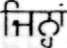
ਜਿਨ੍ਹਾਂ
